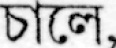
চালে,
